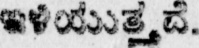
ಇಳಿಯುತ್ತದೆ.
